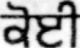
ਕੋਈ
